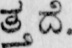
ತ್ತದೆ.
